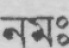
নমঃ
